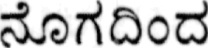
ನೊಗದಿಂದ
